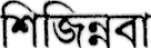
শিজিন্নবা
